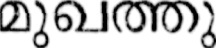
മുഖത്തു
